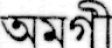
অমগী
